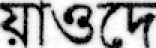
য়াওদে
